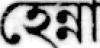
হেন্না
